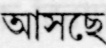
আসছে
